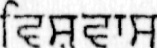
ਵਿਸ਼ਵਾਸ
